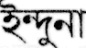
ইন্দুনা
